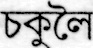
চকুলৈ
